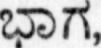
ಭಾಗ,
